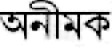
অনীমক
